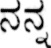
ನನ್ನ
